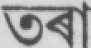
তৰা
